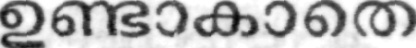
ഉണ്ടാകാതെ
